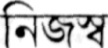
নিজস্ব
